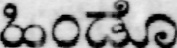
ಹಿಂಡೊ
